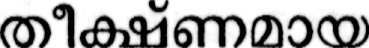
തീക്ഷ്ണമായ
